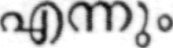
എന്നും
